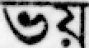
ভয়
